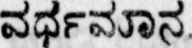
ವರ್ಧಮಾನ.
